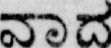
ವಾದ
